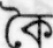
কৈ
